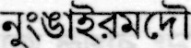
নুংঙাইরমদৌ
